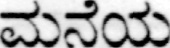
ಮನೆಯ
